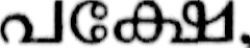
പക്ഷേ,
